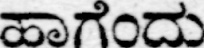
ಹಾಗೆಂದು
